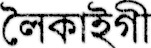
লৈকাইগী
